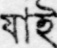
যাই
